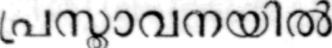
പ്രസ്താവനയില്‍
